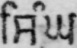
ਸਿੰਘ
